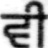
ਵੀ
